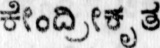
ಕೇಂದ್ರೀಕೃತ
